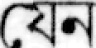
যেন
